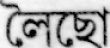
লৈছো
